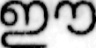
ഈ
